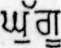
ਘੁੱਗੂ
